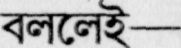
বললেই-
